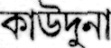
কাউদুনা
